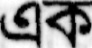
এক
